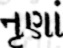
નૃણાં
